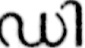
ഡി
